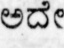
ಅದೇ
